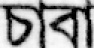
চাবা
